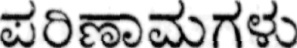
ಪರಿಣಾಮಗಳು
